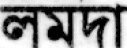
লমদা
